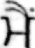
ਮੈਂ
